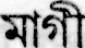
মাগী
